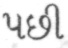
પછી
